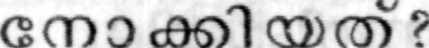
നോക്കിയത്?
